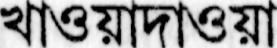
খাওয়াদাওয়া
